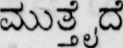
ಮುತ್ತೈದೆ
